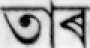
তাৰ
